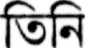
তিনি
